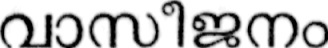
വാസീജനം
